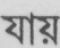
যায়
